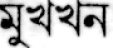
মুখখন
